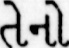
તેનો
